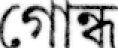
গোন্ধ
